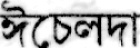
ঈচেলদা
